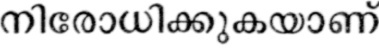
നിരോധിക്കുകയാണ്
